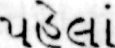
પહેલાં
